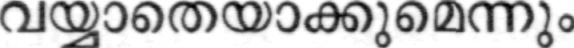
വയ്യാതെയാക്കുമെന്നും
